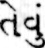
તેવું
